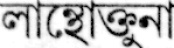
লান্থোক্তুনা
